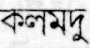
কলমদু
